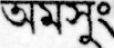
অমসুং
